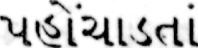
પહોંચાડતાં
